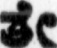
ತೇ
